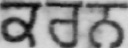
ਕਰਨ
